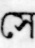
সে
